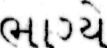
ભાગ્યે
